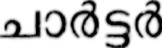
ചാര്‍ട്ടര്‍
